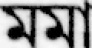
মমা
